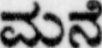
ಮನೆ
